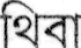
থিবা
